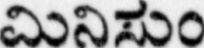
ಮಿನಿಸುಂ
